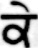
ਕੇ
